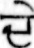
ਦੇ
